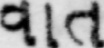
વાત
